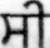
ਸੀ
